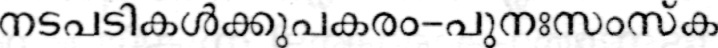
നടപടികള്‍ക്കുപകരം-പുനഃസംസ്ക
